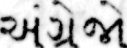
અંગ્રેજો
